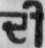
ਦੀ
